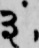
રૂં,
